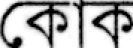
কোক
